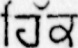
ਹਿੱਕ
